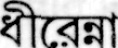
ধীরেন্না
